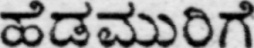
ಹೆಡಮುರಿಗೆ
